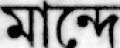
মান্দে
